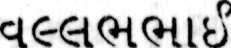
વલ્લભભાઈ
